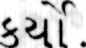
કર્યો.
